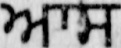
ਆਸ
